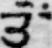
ਤੋਂ
